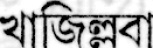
খাজিল্লবা
